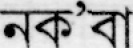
নক'বা
